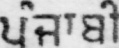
ਪੰਜਾਬੀ
